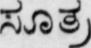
ಸೂತ್ರ
